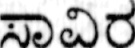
ಸಾವಿರ
